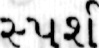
સ્પર્શ
